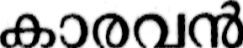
കാരവന്‍
